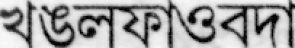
খঙলফাওবদা
